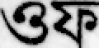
ওফ
